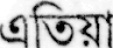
এতিয়া
